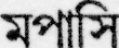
মপাসি
